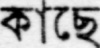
কাছে
